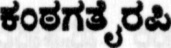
ಕಂಠಗತೈರಪಿ
